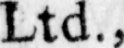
Ltd.,
